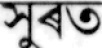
সুৰত
